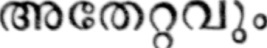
അതേറ്റവും
